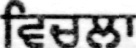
ਵਿਚਲਾ
